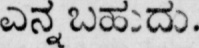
ಎನ್ನಬಹುದು.
